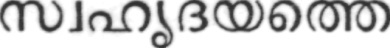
സ്വഹൃദയത്തെ
